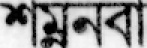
শম্ননবা
